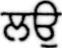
ਲਉ
